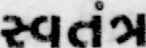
સ્વતંત્ર
